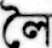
লৈ
